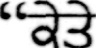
''ਕੇਤੇ
